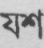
যশ
